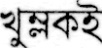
খুম্লকই
